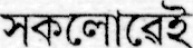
সকলোৱেই
